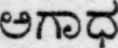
ಅಗಾಧ
